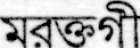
মরক্তগী
